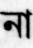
না
